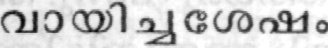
വായിച്ചശേഷം
